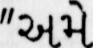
"અમે
